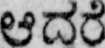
ಆದರೆ
